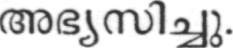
അഭ്യസിച്ചു.
